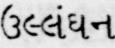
ઉલ્લંઘન
